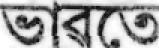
ভাৱতে
